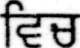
ਵਿਚ
